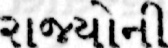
રાજ્યોની
